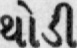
થોડી
